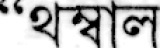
“থম্বাল
